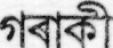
গৰাকী
